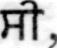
ਸੀ,
